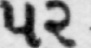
પર
